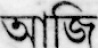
আজি
